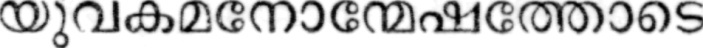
യുവകമനോന്മേഷത്തോടെ
